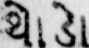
થોડો
